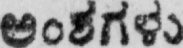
ಅಂಶಗಳು
